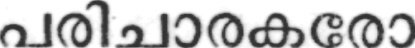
പരിചാരകരോ
